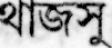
থাজসু
